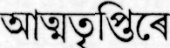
আত্মতৃপ্তিৰে
